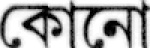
কোনো
